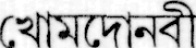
খোমদোনবী
